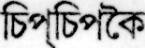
চিপচিপকৈ
